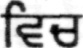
ਵਿਚ
